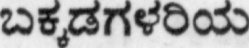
ಬಕ್ಕಡಗಳರಿಯ
